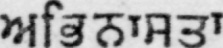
ਅਭਿਨਾਸਤਾ
